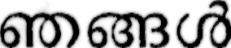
ഞങ്ങള്‍
